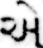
એ
